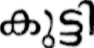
കുട്ടി
